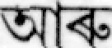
আৰু
